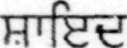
ਸ਼ਾਇਦ
